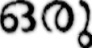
ഒരു
